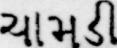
ચામડી
